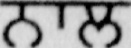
ਨਾਲ
